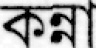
কন্না
